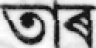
তাৰ
